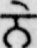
ਨੇ
